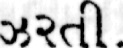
ઝરતી.
